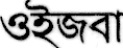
ওইজবা
